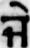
ਜੇ
